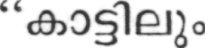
"കാട്ടിലും
